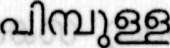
പിമ്പുള്ള
